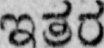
ಇತರ
